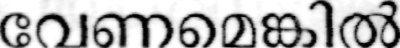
വേണമെങ്കില്‍
